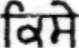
ਕਿਸੇ
